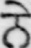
ਨੇ
